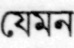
যেমন
